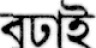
বুঢাই
